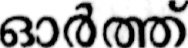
ഓര്‍ത്ത്
